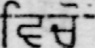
ਵਿਚੋਂ
